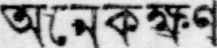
অনেকক্ষণ
